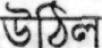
উঠিল
